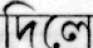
দিলে
